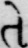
તે
